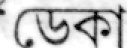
'ডেকা
